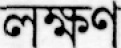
লক্ষণ
